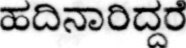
ಹದಿನಾರಿದ್ದರೆ
